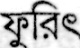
ফুরিৎ
